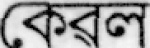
কেৱল
